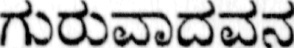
ಗುರುವಾದವನ
